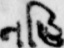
નહિ
